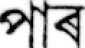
পাৰ
